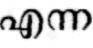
എന്ന
